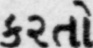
કરતો
